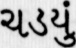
ચડયું
